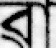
ৱা
